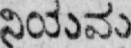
ನಿಯಮ
